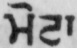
ਮੋਟਾ
